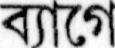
ব্যাগে
